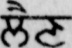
ਲੈਣ
